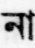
না
